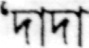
‘দাদা
